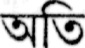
অতি
